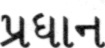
પ્રધાન
